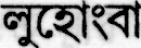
লুহোংবা
